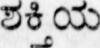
ಶಕ್ತಿಯ
